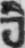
ਹੈ
